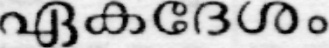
ഏകദേശം
